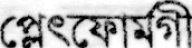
প্লেৎফোর্মগী
